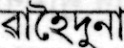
ৱাহৈদুনা
